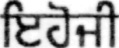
ਇਹੋਜੀ
